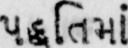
પદ્ધતિમાં
